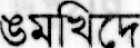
ঙমখিদে
